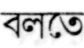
বলতে
